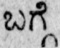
ಬಗ್ಗೆ
